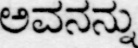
ಅವನನ್ನು
